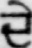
ਦੇ
